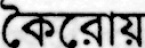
কৈরোয়
